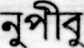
নুপীবু
